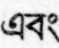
এবং
